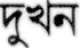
দুখন
